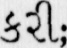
કરી
